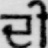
ਦੀ
